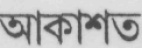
আকাশত
